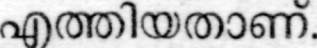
എത്തിയതാണ്.
